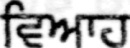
ਵਿਆਹ
